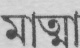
মাত্মা
